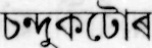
চন্দুকটোৰ
